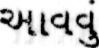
આવવું
